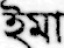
ইমা
